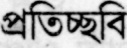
প্রতিচ্ছবি
